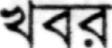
খবর
